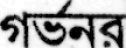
গর্ভনর
